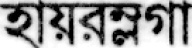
হায়রম্লগা
